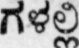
ಗಳಲ್ಲಿ
